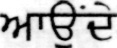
ਆਉਂਦੇ
